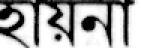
হায়না
